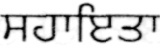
ਸਹਾਇਤਾ
